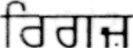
ਰਿਗਜ਼
